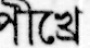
পীখ্রে
